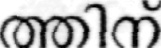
ത്തിന്
